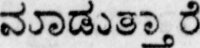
ಮಾಡುತ್ತಾರೆ
